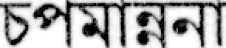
চপমান্ননা
